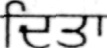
ਦਿਤਾ
